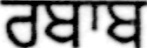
ਰਬਾਬ
